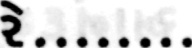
રે...............
